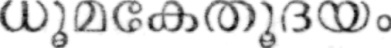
ധൂമകേതൂദയം
